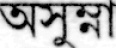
অসুম্না
